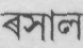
ৰসাল
